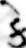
કે
